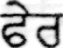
ਫੇਰ
